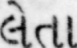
લેતા
